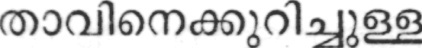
താവിനെക്കുറിച്ചുള്ള
